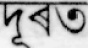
দূৰত
